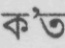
ক'ত
